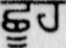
ਛੂਹ
